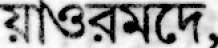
য়াওরমদে,
